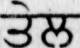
ਤੇਲ
